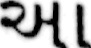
આ
